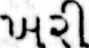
ખરી
